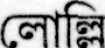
লোল্লি
